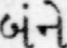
બંને
